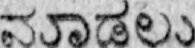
ಮಾಡಲು
